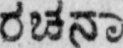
ರಚನಾ
